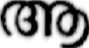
ആ
